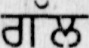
ਗੱਲ
